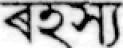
ৰহস্য
